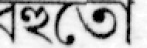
বহুতো
